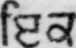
ਇਕ
